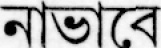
নাভাবে
